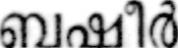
ബഷീര്‍
